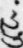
હું
